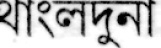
থাংলদুনা
